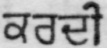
ਕਰਦੀ
